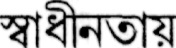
স্বাধীনতায়
